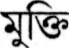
মুক্তি
